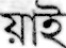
য়াই
